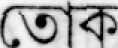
তোক
